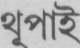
থূপাই
